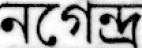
নগেন্দ্র
